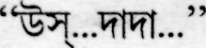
"উস্‌...দাদা..."
